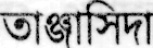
তাঞ্জাসিদা
